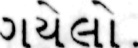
ગયેલો.
